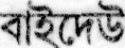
বাইদেউ
